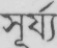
সূর্য্য
